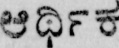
ಆರ್ಥಿಕ
